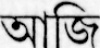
আজি
